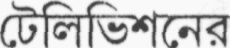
টেলিভিশনের
